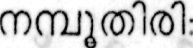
നമ്പൂതിരി:
